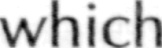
which
